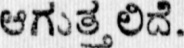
ಆಗುತ್ತಲಿದೆ.
